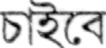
চাইবে
